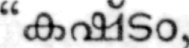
“കഷ്ടം,
